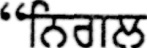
''ਨਿਗਲ
